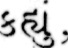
કહ્યું,
